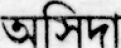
অসিদা
